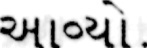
આવ્યો.
